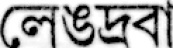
লেঙদ্রবা
